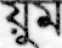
য়ুম
